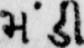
મંડી
